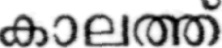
കാലത്ത്
